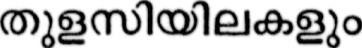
തുളസിയിലകളും
